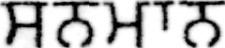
ਸਨਮਾਨ
